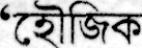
‘হৌজিক
